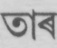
তাৰ
